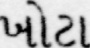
ખોટા
